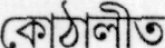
কোঠালীত
